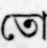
তো
